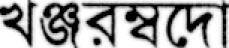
খঞ্জরম্বদো
